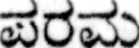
ಪರಮ
